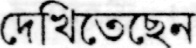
দেখিতেছেন
